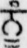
ਨੂੰ
